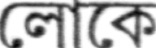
লোকে
